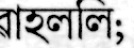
ৱাহললি;
